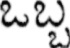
ಒಬ್ಬ
